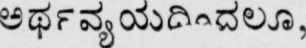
ಅರ್ಥವ್ಯಯದಿಂದಲೂ,
